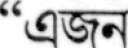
"এজন
